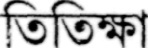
তিতিক্ষা
